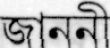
জাননী
